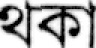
থকা
